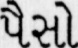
પૈસો
